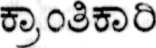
ಕ್ರಾಂತಿಕಾರಿ
